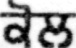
ਕੋਲ
